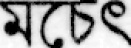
মচেৎ
